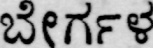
ಬೇರ್ಗಳ
